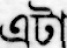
এটা
